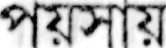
পয়সায়
